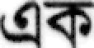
এক
